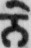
ਨੇ
